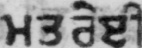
ਮਤਰੇਈ
